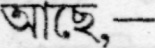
আছে,—
